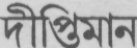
দীপ্তিমান
